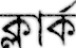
ক্লার্ক
